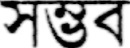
সম্ভব
